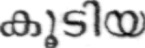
കൂടിയ
